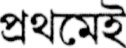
প্রথমেই
